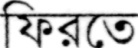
ফিরতে
